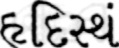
હ્રદિસ્થં
